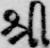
શ્રી
